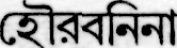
হৌরবনিনা
